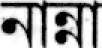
নান্না
